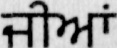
ਜੀਆਂ
